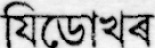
যিডোখৰ
